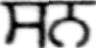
ਸਨ
